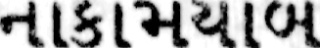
નાકામયાબ
